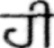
ਹੀ
